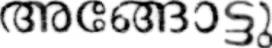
അങ്ങോട്ടു
